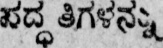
ಪದ್ಧತಿಗಳನ್ನು
